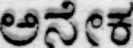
ಅನೇಕ
